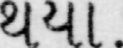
થયા.
